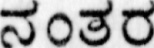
ನಂತರ
